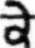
ਕੇ
